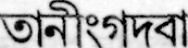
তানীংগদবা
